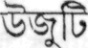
উজুটি
